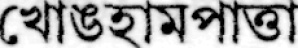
খোঙহামপাত্তা
